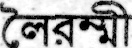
লৈরম্মী
